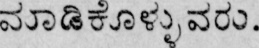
ಮಾಡಿಕೊಳ್ಳುವರು.
